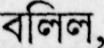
বলিল,
